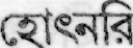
হোৎনরি
